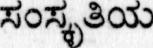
ಸಂಸ್ಕೃತಿಯ
